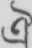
ঐ
